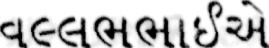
વલ્લભભાઈએ
